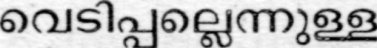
വെടിപ്പല്ലെന്നുള്ള
